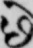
છે
